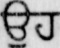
ਉਹ
